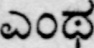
ಎಂಥ
